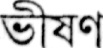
ভীষণ
